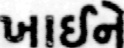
ખાઈને
